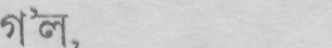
গ'ল,
